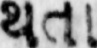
થતા
